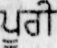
ਪੂਰੀ
